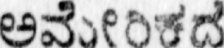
ಅಮೇರಿಕದ
